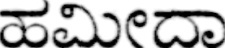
ಹಮೀದಾ
